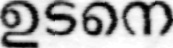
ഉടനെ
